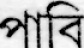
পাবি
